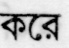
করে
